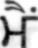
ਮੈਂ
